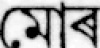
মোৰ
